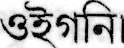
ওইগনি।
